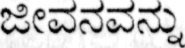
ಜೀವನವನ್ನು
